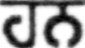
ਹਨ
